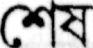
শেষ
